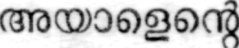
അയാളെന്റെ
